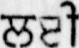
ਲਈ
